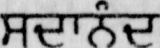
ਸਦਾਨੰਦ
